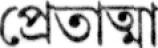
প্রেতাত্মা
